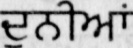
ਦੁਨੀਆਂ
